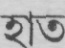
হাত
